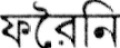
ফরৈনি
